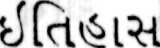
ઈતિહાસ
